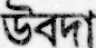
উবদা
